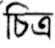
চিত্র
